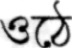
ওঠে
